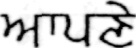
ਆਪਣੇ
